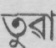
তুৱা
